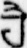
ਹੈ
